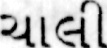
ચાલી
